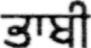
ਭਾਬੀ
